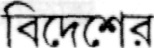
বিদেশের
